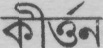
কীৰ্ত্তন
